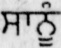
ਸਾਨੂੰ
